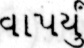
વાપર્યું
